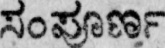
ಸಂಪೂರ್ಣ
